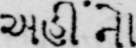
અહીંનો
